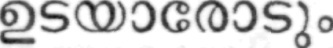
ഉടയാരോടും
